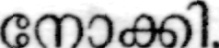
നോക്കി.
